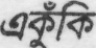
একুঁকি
